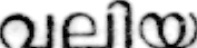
വലിയ
